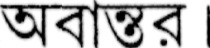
অবান্তর।
